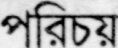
পরিচয়
